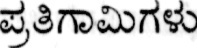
ಪ್ರತಿಗಾಮಿಗಳು
